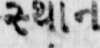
સ્થાન
